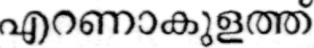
എറണാകുളത്ത്
